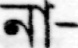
না-
